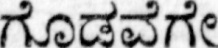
ಗೊಡವೆಗೇ
